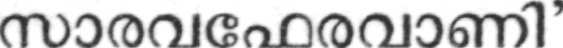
സാരവഫേരവാണി'
